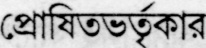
প্রোষিতভর্তৃকার
